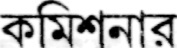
কমিশনার
